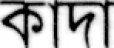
কাদা
